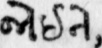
જોઈને,
